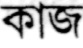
কাজ
